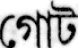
গোট
